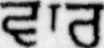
ਵਾਰ
